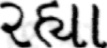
રહ્યા
